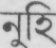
নুহি
